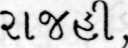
રાજહી,
